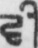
ਵੀ
